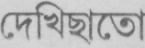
দেখিছাতো
